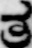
ತ
